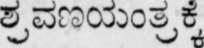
ಶ್ರವಣಯಂತ್ರಕ್ಕೆ
